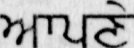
ਆਪਣੇ
